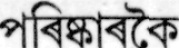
পৰিষ্কাৰকৈ
